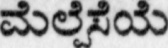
ಮೆಲ್ಪೆಸೆಯೆ
